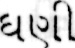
ઘણી
